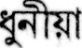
ধুনীয়া
